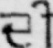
ਦੀ
